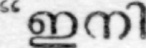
"ഇനി
